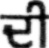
ਦੀ
